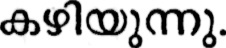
കഴിയുന്നു.
